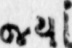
જ્યાં
